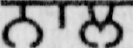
ਨਾਲ
